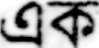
এক
